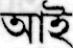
আই
